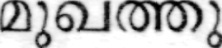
മുഖത്തു
